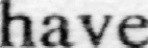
have
